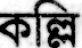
কল্লি
